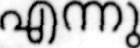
എന്നു
